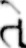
તે
